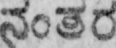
ನಂತರ
